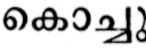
കൊച്ചു
